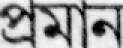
প্রমান
